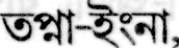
তপ্না-ইংনা,
